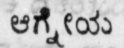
ಆಗ್ನೇಯ
